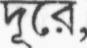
দূরে,
